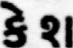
કેશ
